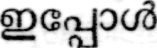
ഇപ്പോള്‍
